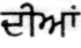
ਦੀਆਂ
